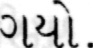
ગયો.
